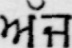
ਅੱਜ
